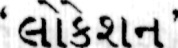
'લોકેશન'
